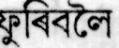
ফুৰিবলৈ
